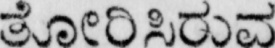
ತೋರಿಸಿರುವ
